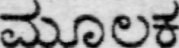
ಮೂಲಕ
